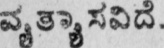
ವ್ಯತ್ಯಾಸವಿದೆ.
